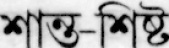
শান্ত-শিষ্ট
